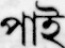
পাই
